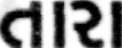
તારા
